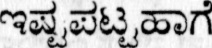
ಇಷ್ಟಪಟ್ಟಹಾಗೆ
